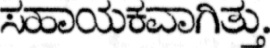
ಸಹಾಯಕವಾಗಿತ್ತು.
